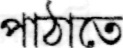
পাঠাতে
